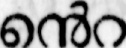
ന്റെ
